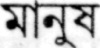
মানুষ
